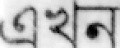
এখন
